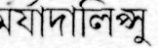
মর্যাদালিপ্সু
